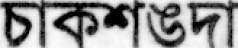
চাকশঙদা
